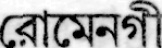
রোমেনগী
